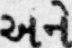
અને
